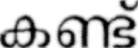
കണ്ട്
